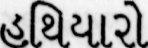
હથિયારો
